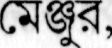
মেঞ্জুর,
